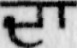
ਦਾ
